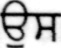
ਉਸ
